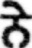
ਨੇ
